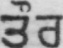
ਤੌਰ
